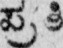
ಪ್ರತಿ
